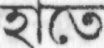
হাতে
